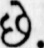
છે.
